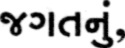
જગતનું,
